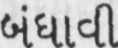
બંધાવી
